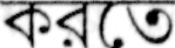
করতে
